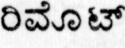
ರಿಮೊಟ್
